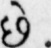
છે.
